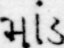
માંડ
